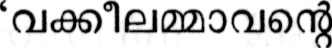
'വക്കീലമ്മാവന്റെ
